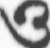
ও
